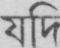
যদি
